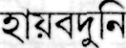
হায়বদুনি
